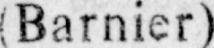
(Barnier)
